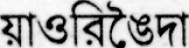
য়াওরিঙৈদা
